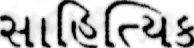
સાહિત્યિક
